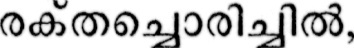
രക്തച്ചൊരിച്ചില്‍,
